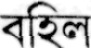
বহিল
